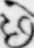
છે
